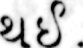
થઈ.
